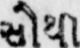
સૌથી
